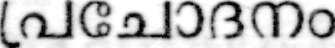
പ്രചോദനം
